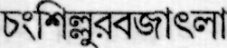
চংশিল্লুরবজাৎলা
